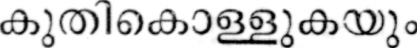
കുതികൊള്ളുകയും
